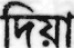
দিয়া
